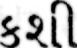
કશી
